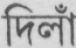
দিলাঁ
